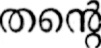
തന്റെ
